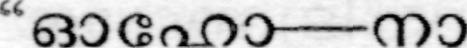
"ഓഹോ-നാ
